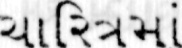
ચારિત્રમાં
